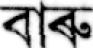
বাৰু
